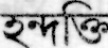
হন্দক্তি
